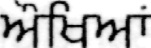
ਔਖਿਆ
